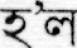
হ'ল
